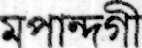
মপান্দগী
